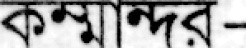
কম্মান্দর-
